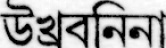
উখ্রবনিনা
